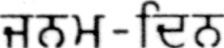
ਜਨਮ-ਦਿਨ
